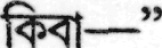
কিবা-"
